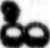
ಹಿ
